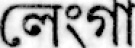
লেংগা
